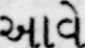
આવે
